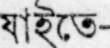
যাইতে-
